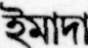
ইমাদা
